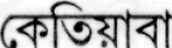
কেতিয়াবা
